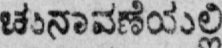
ಚುನಾವಣೆಯಲ್ಲಿ
